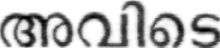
അവിടെ
